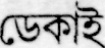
ডেকাই
